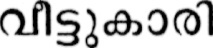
വീട്ടുകാരി
